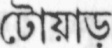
টোয়াড়
